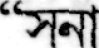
“সনা
